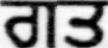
ਗਤ
